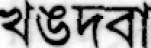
খঙদবা
